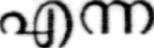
എന്ന
